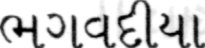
ભગવદીયા
